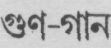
গুণ-গান
